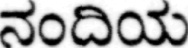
ನಂದಿಯ
